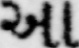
આ
